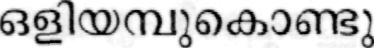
ഒളിയമ്പുകൊണ്ടു
